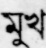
মুখ
